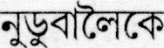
নুডুবালৈকে
